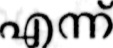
എന്ന്
